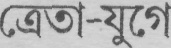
ত্ৰেতা-যুগে
